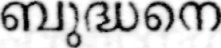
ബുദ്ധനെ
